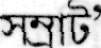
সম্রাট’
